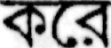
করে
